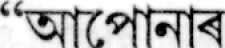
"আপোনাৰ
